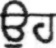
ਉਹ
